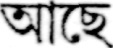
আছে
